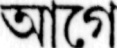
আগে
